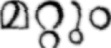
മറ്റും
